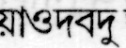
য়াওদবদু
